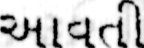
આવતી
